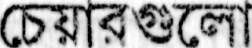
চেয়ারগুলো
